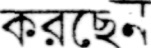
করছেন
